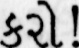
કરો!
